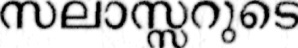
സലാസ്സറുടെ
